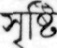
সৃষ্টি
